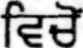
ਵਿਚੋਂ
